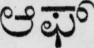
ಆಫ್
